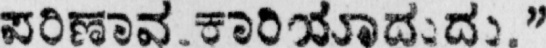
ಪರಿಣಾಮಕಾರಿಯಾದುದು.”
